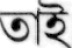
তাই
